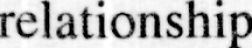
relationship
